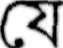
যে
